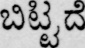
ಬಿಟ್ಟಿದೆ
